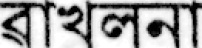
ৱাখলনা
